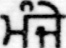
ਮੰਜੇ
